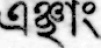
এঞ্ছাং
